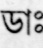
ডাঃ
